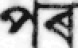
পৰ
